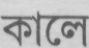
কালে
